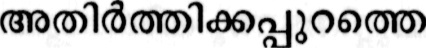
അതിര്‍ത്തിക്കപ്പുറത്തെ
